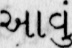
આવું
